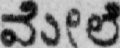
ಮೇಲೆ
